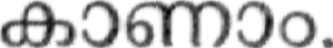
കാണാം.
